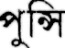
পুন্সি
